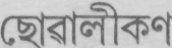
ছোৱালীকণ
